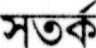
সতর্ক
